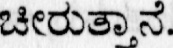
ಚೀರುತ್ತಾನೆ.
